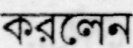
করলেন
